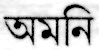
অমনি
